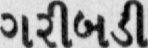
ગરીબડી
